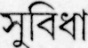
সুবিধা
